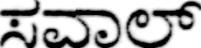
ಸವಾಲ್
